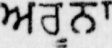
ਅਰੂਨਾ
